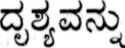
ದೃಶ್ಯವನ್ನು
